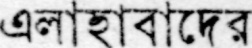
এলাহাবাদের
